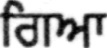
ਗਿਆ
